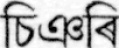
চিঞৰি
